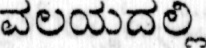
ವಲಯದಲ್ಲಿ
